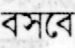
বসবে
